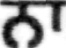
ਨਾ
